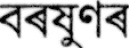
বৰষুণৰ
